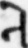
ને
